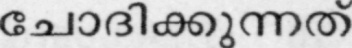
ചോദിക്കുന്നത്
